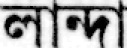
লান্দা
